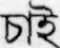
চাই
